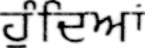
ਹੁੰਦਿਆਂ
